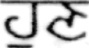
ਹੁਣ
